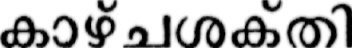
കാഴ്ചശക്തി
